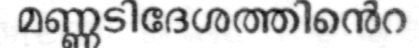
മണ്ണടിദേശത്തിന്റെ
